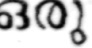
ഒരു
